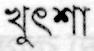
খুৎশা
